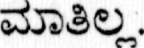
ಮಾತಿಲ್ಲ.
